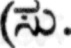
(ಸು.
